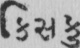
કિસકુ
